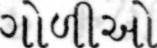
ગોળીઓ
